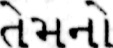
તેમનો
